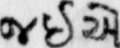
જઈએ
